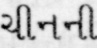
ચીનની
